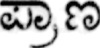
ಪ್ರಾಣ
